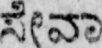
ಸೇವಾ
